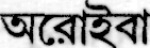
অরোইবা
